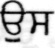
ਉਸ
